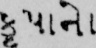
કૃપાનો
